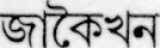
জাকৈখন
